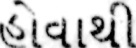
હોવાથી
